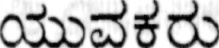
ಯುವಕರು
